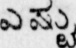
ಎಷ್ಟು
